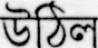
উঠিল
